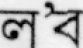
ল'ব
